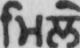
ਮਿਲੇ
